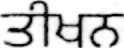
ਤੀਖਨ
